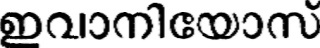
ഇവാനിയോസ്
